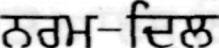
ਨਰਮ-ਦਿਲ
